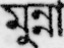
মুন্না
